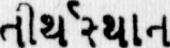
તીર્થસ્થાન
